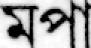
মপা
